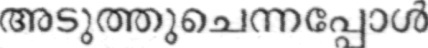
അടുത്തുചെന്നപ്പോള്‍
